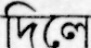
দিলে
